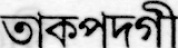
তাকপদগী
